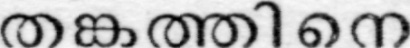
തങ്കത്തിനെ
